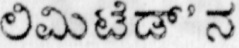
ಲಿಮಿಟೆಡ್’ನ
